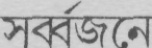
সৰ্ব্বজনে
